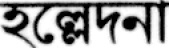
হল্লেদনা
